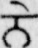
ਨੇ
